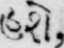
હશે,
